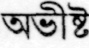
অভীষ্ট
